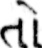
તો
